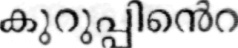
കുറുപ്പിന്റെ
